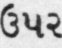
ઉપર
